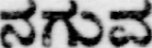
ನಗುವ
